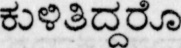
ಕುಳಿತಿದ್ದರೊ
